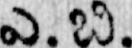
ಎ.ಬಿ.
